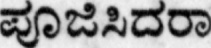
ಪೂಜಿಸಿದರಾ
